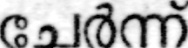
ചേര്‍ന്ന്
